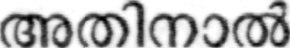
അതിനാല്‍
